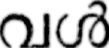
വള്‍
